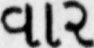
વાર
